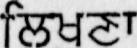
ਲਿਖਣਾ
